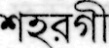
শহরগী
